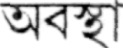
অবস্থা
